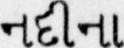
નદીના
